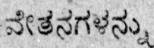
ವೇತನಗಳನ್ನು
